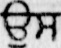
ਉਸ
